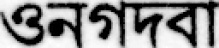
ওনগদবা
